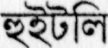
হুইটলি
